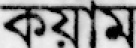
কয়াম
